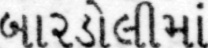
બારડોલી
